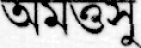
অমত্তসু
